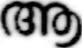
ആ
